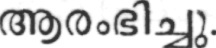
ആരംഭിച്ചു.
